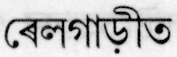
ৰেলগাড়ীত
